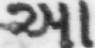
આ
